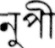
নুপী
